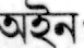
অইন
